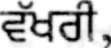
ਵੱਖਰੀ,
